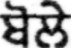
ਬੋਲੇ
